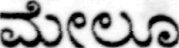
ಮೇಲೂ
